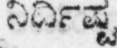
ನಿರ್ದಿಷ್ಟ
